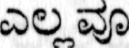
ಎಲ್ಲವೂ
